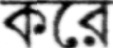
করে
